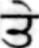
ਤੇ
